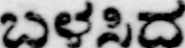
ಬಳಸಿದ
